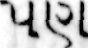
પણ
